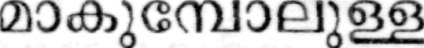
മാകുമ്പോലുള്ള
